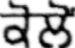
ਕੋਲੋਂ
